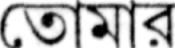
তোমার
